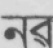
নৱ
